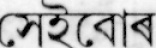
সেইবোৰ
